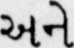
અને
